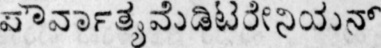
ಪೌರ್ವಾತ್ಯಮೆಡಿಟರೇನಿಯನ್
